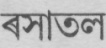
ৰসাতল
